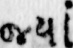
જ્યાં
